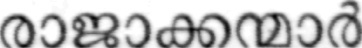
രാജാക്കന്മാര്‍
